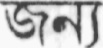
জন্য
